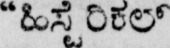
“ಹಿಸ್ಟೆರಿಕಲ್
